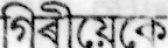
গিৰীয়েকে
